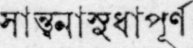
সান্ত্বনাসুধাপূর্ণ
